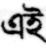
এই
